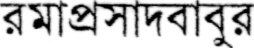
রমাপ্রসাদবাবুর
